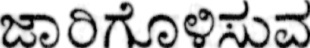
ಜಾರಿಗೊಳಿಸುವ
